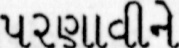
પરણાવીને
